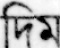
দিম
